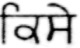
ਕਿਸੇ
